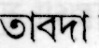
তাবদা
